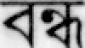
বন্ধ
